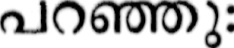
പറഞ്ഞു:
